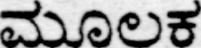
ಮೂಲಕ
